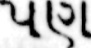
પણ
